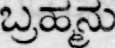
ಬ್ರಹ್ಮನು
